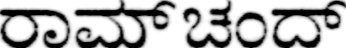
ರಾಮ್ಚಂದ್
